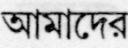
আমাদের
